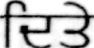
ਦਿਤੇ
